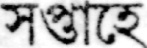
সপ্তাহে
